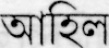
আহিল
